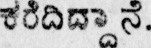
ಕರೆದಿದ್ದಾನೆ.
